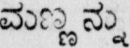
ಮಣ್ಣನ್ನು
